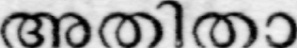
അതിതാ
